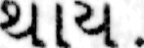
થાય.
